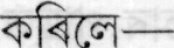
কৰিলে-
